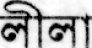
লীলা
